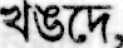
খঙদে,
